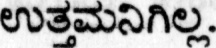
ಉತ್ತಮನಿಗಿಲ್ಲ.
